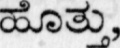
ಹೊತ್ತು,
